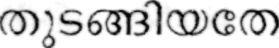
തുടങ്ങിയതേ
